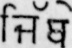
ਜਿੱਥੇ
